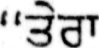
''ਤੇਰਾ
